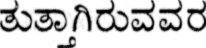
ತುತ್ತಾಗಿರುವವರ
